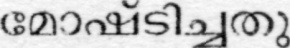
മോഷ്ടിച്ചതു
